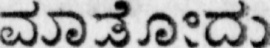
ಮಾಡೋದು
